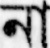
না
